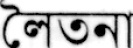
লৈতনা
